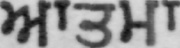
ਆਤਮਾ
